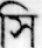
সি
